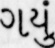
ગયું
